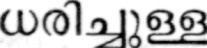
ധരിച്ചുള്ള
